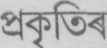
প্রকৃতিৰ
